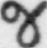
જ
